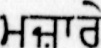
ਮਜ਼ਾਰੇ
